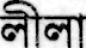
লীলা
